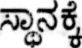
ಸ್ಥಾನಕ್ಕೆ
